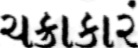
ચક્રાકારં
